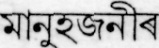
মানুহজনীৰ
